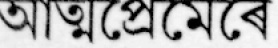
আত্মপ্রেমেৰে
